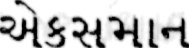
એકસમાન
